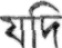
যদি
